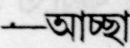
–আচ্ছা
